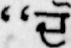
''ਦੋ
